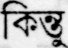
কিন্তু
